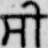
ਸੀ
